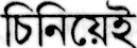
চিনিয়েই
